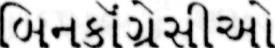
બિનકૉંગ્રેસીઓ
